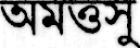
অমত্তসু
